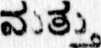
ಮತ್ತು
